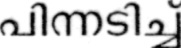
പിന്നടിച്ച്
